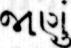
જાણું
